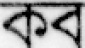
কব
